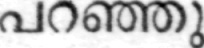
പറഞ്ഞു
